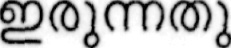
ഇരുന്നതു
